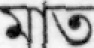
মাত
